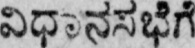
ವಿಧಾನಸಭೆಗೆ
